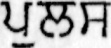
ਪੁਲਸ
